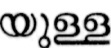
യുള്ള
